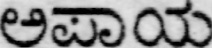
ಅಪಾಯ
